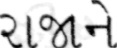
રાજાને
